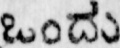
ಒಂದು
